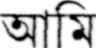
আমি
